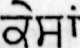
ਕੇਸਾਂ
